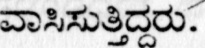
ವಾಸಿಸುತ್ತಿದ್ದರು.
